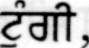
ਟੁੰਗੀ,
